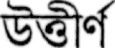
উত্তীর্ণ
